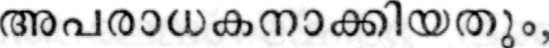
അപരാധകനാക്കിയതും,
